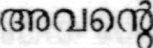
അവന്റെ
